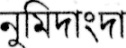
নুমিদাংদা
